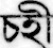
চহী
